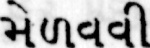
મેળવવી
